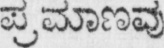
ಪ್ರಮಾಣವು
